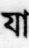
যা
